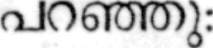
പറഞ്ഞു:
